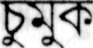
চুমুক
